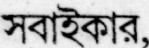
সবাইকার,
